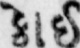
કોઈ
